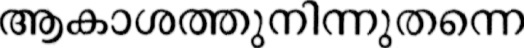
ആകാശത്തുനിന്നുതന്നെ
